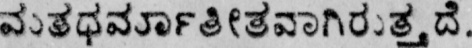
ಮತಧರ್ಮಾತೀತವಾಗಿರುತ್ತದೆ.
